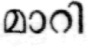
മാറി
